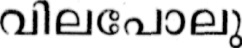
വിലപോലു
